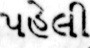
પહેલી
